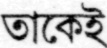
তাকেই
